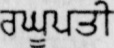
ਰਘੂਪਤੀ
